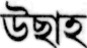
উছাহ
